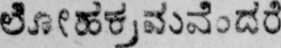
ಲೋಹಕ್ರಮವೆಂದರೆ
